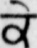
ਕੇ
